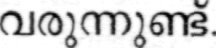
വരുന്നുണ്ട്.
